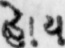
હોય
